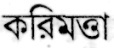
করিমত্তা
